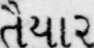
તૈયાર
